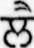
ਲੈ
